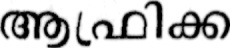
ആഫ്രിക്ക
